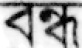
বন্ধ
